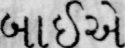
બાઈએ
